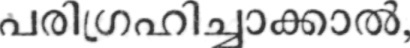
പരിഗ്രഹിച്ചാക്കാല്‍,
